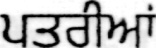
ਪਤਰੀਆਂ
